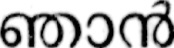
ഞാന്‍
